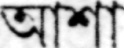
আশা
